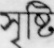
সৃষ্টি
